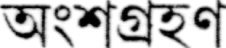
অংশগ্রহণ
